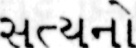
સત્યનો
